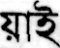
য়াই
